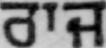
ਰਾਜ
